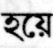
হয়ে
